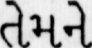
તેમને
